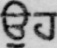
ਉਹ
